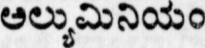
ಅಲ್ಯುಮಿನಿಯಂ
